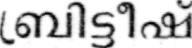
ബ്രിട്ടീഷ്
